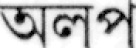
অলপ
